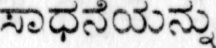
ಸಾಧನೆಯನ್ನು
